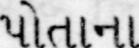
પોતાના
